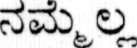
ನಮ್ಮೆಲ್ಲ
